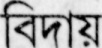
বিদায়
